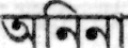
অনিনা
